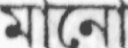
মানো
